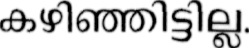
കഴിഞ്ഞിട്ടില്ല.
